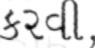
કરવી,
